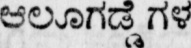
ಆಲೂಗಡ್ಡೆಗಳ
